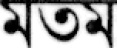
মতম
